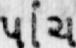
પાંચ
